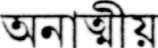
অনাত্মীয়
